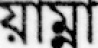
য়াম্না
